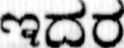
ಇದರ
